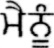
ਮੈਨੂੰ
